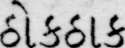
ઠોકઠાક
